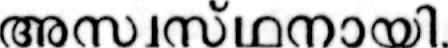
അസ്വസ്ഥനായി.
